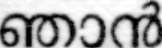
ഞാന്‍
